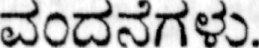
ವಂದನೆಗಳು.
